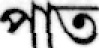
পাত
